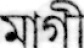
মাগী
